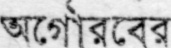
অগৌরবের
